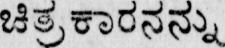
ಚಿತ್ರಕಾರನನ್ನು
